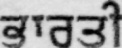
ਭਾਰਤੀ
